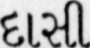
દાસી
